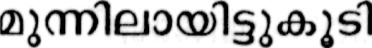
മുന്നിലായിട്ടുകൂടി
